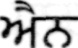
ਐਨ
